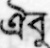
ঐবু
